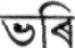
ভৰি
